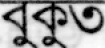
বুকুত
